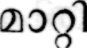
മാറ്റി
